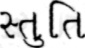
સ્તુતિ
